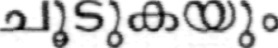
ചൂടുകയും
